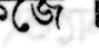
কিজৈ
